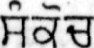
ਸੰਕੋਚ
